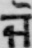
ਜੋ
